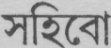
সহিবো
